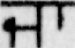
ਜਾ
